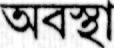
অবস্থা
